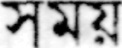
সময়
